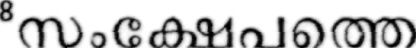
8സംക്ഷേപത്തെ
